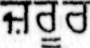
ਜ਼ਰੂਰ
